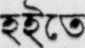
হইতে
